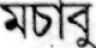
মচাবু
